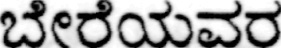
ಬೇರೆಯವರ
